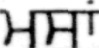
ਮਸਾਂ
